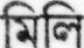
মিলি
